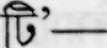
টি'-
